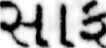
સાફ
